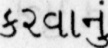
કરવાનું
